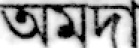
অমদা
